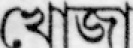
খোজা
